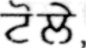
ਟੋਲੇ,
